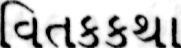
વિતકકથા
